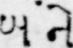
બંને
